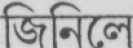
জিনিলে
